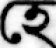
হে
